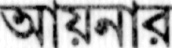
আয়নার
